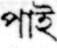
পাই
